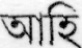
আহি
